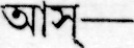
আস্-
